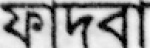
ফাদবা
